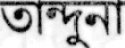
তান্দুনা
